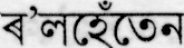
ৰ'লহেঁতেন
